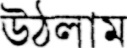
উঠলাম
